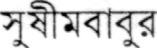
সুষীমবাবুর
